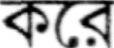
করে
